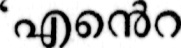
‘എന്റെ
